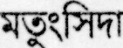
মতুংসিদা
